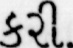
કરી.
